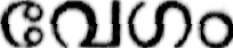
വേഗം
